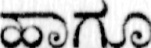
ಹಾಗೂ
